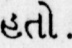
હતો.
